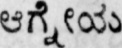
ಆಗ್ನೇಯ
